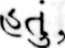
હતું,
